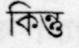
কিন্তু
